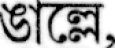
ঙাল্লে,
